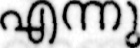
എന്നു
